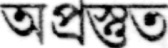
অপ্রস্তুত
